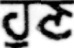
ਹੁਣ
